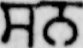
ਸਨ
